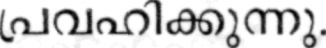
പ്രവഹിക്കുന്നു.
